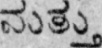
ಮತ್ತು
